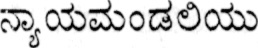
ನ್ಯಾಯಮಂಡಲಿಯು
